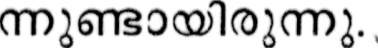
ന്നുണ്ടായിരുന്നു.
